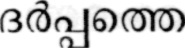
ദര്‍പ്പത്തെ
